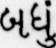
બધું
